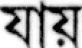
যায়
